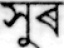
সুৰ
